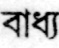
বাধ্য
